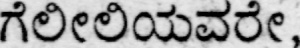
ಗೆಲೀಲಿಯವರೇ,
